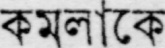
কমলাকে
